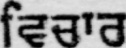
ਵਿਚਾਰ
